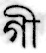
গী
